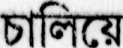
চালিয়ে
